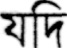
যদি
